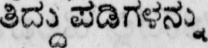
ತಿದ್ದುಪಡಿಗಳನ್ನು
